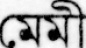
মেমী
